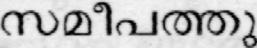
സമീപത്തു
